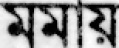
মমায়
